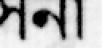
সনা
